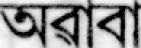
অৱাবা
